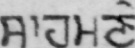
ਸਾਹਮਣੇ
